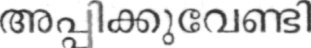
അപ്പിക്കുവേണ്ടി
